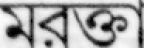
মরক্তা
